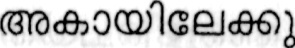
അകായിലേക്കു
